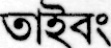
তাইবং
